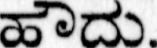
ಹೌದು.
